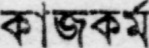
কাজকর্ম
